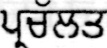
ਪ੍ਰਚੱਲਤ
